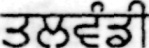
ਤਲਵੰਡੀ
